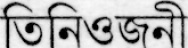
তিনিওজনী
